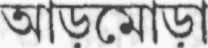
আড়মোড়া
